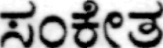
ಸಂಕೇತ
